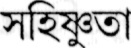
সহিষ্ণুতা
